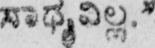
ಸಾಧ್ಯವಿಲ್ಲ.”
